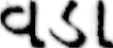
વડા
